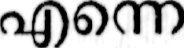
എന്നെ
